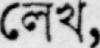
লেখ,
